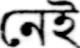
নেই
